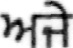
ਅਜੇ
